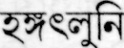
হঙ্গৎলুনি
